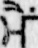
ਮੈਂ
